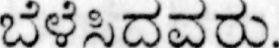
ಬೆಳೆಸಿದವರು.
